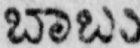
ಬಾಬು
